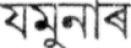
যমুনাৰ
